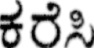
ಕರೆಸಿ
